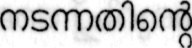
നടന്നതിന്റെ
